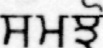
ਸਮਝੋ
